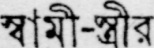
স্বামী-স্ত্রীর
